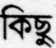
কিছু
